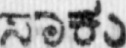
ಸಾಕು
